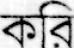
করি
